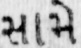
સામે
